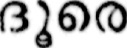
ദൂരെ
